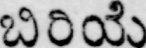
ಬಿರಿಯೆ
